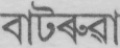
বাটৰুৱা
